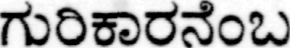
ಗುರಿಕಾರನೆಂಬ
